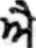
ਐ
